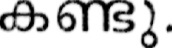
കണ്ടു.
